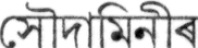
সৌদামিনীৰ
